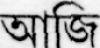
আজি
